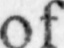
of
